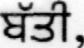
ਬੱਤੀ,
